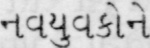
નવયુવકોને
